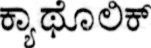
ಕ್ಯಾಥೊಲಿಕ್
